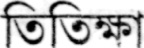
তিতিক্ষা
